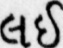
લઈ
